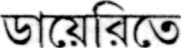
ডায়েরিতে
